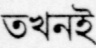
তখনই
